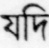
যদি
